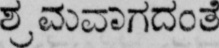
ಶ್ರಮವಾಗದಂತೆ
